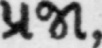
પ્રજા,
